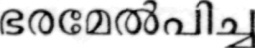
ഭരമേല്‍പിച്ച
